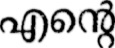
എന്റെ
